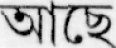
আছে
